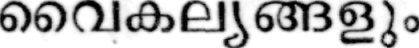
വൈകല്യങ്ങളും
